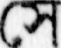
সে
